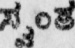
ಸ್ವಂತ
